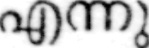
എന്നു
